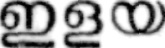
ഇളയ
